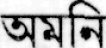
অমনি
